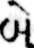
બે
